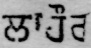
ਲਾਹੌਰ
